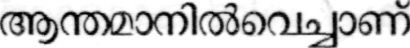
ആന്തമാനില്‍വെച്ചാണ്
